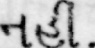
નહી.
